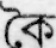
কৈ
